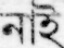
নাই
